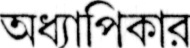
অধ্যাপিকার
